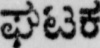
ಘಟಕ
